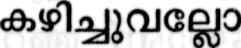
കഴിച്ചുവല്ലോ
